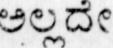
ಅಲ್ಲದೇ
